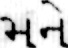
મને
